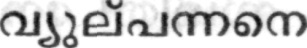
വ്യുല്പന്നനെ
